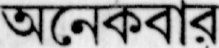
অনেকবার
